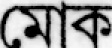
মোক
